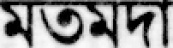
মতমদা
